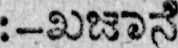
:-ಖಜಾನೆ
